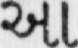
આ
